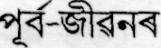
পূর্ব-জীৱনৰ
